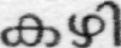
കഴി
